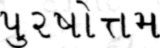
પુરુષોત્તમ
